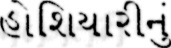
હોશિયારીનું
